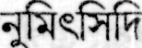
নুমিৎসিদি
